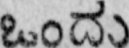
ಒಂದು
